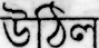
উঠিল
